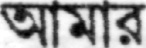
আমার
